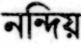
নন্দিয়
